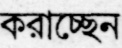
করাচ্ছেন
